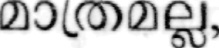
മാത്രമല്ല,
